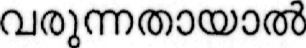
വരുന്നതായാല്‍
